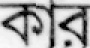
কার
